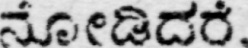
ನೋಡಿದರೆ,
